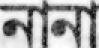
নানা
